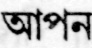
আপন
